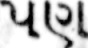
પણ
